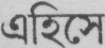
এহিসে
